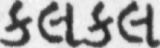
કલકલ
